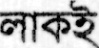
লাকই
